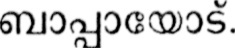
ബാപ്പായോട്.
